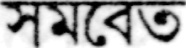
সমবেত
